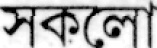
সকলো
